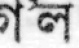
গ'ল
